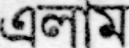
এলাম
